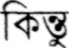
কিন্তু
